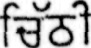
ਚਿੱਠੀ
